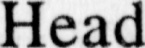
Head
